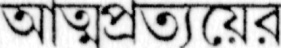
আত্মপ্রত্যয়ের
